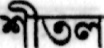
শীতল
